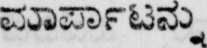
ಮಾರ್ಪಾಟನ್ನು
